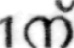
1ന്
